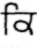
ਕਿ
